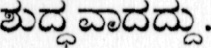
ಶುದ್ಧವಾದದ್ದು.
